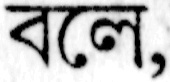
বলে,
